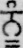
ਨੂੰ
